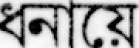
ধনায়ে
